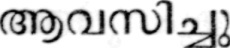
ആവസിച്ചു
